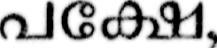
പക്ഷേ,
